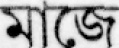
মাজে
